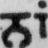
ਨਾਂ
